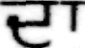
ਦਾ
